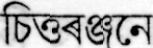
চিত্তৰঞ্জনে
